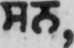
ਸਨ,
